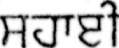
ਸਹਾਈ
